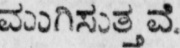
ಮುಗಿಸುತ್ತವೆ.
